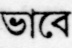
ভাবে
